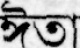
ঈতা
